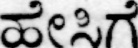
ಹೇಸಿಗೆ
